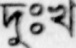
দুঃখ
